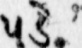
પડે.'
